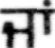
ਜਾਂ
